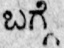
ಬಗ್ಗೆ
